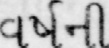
વર્ષની
